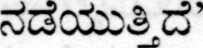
ನಡೆಯುತ್ತಿದೆ'
